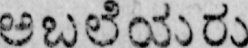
ಅಬಲೆಯರು
